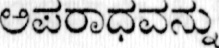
ಅಪರಾಧವನ್ನು
